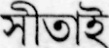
সীতাই
